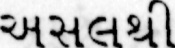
અસલથી
